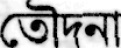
তৌদনা
